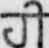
ਹੀ
